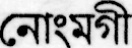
নোংমগী
